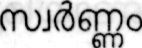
സ്വര്‍ണ്ണം
